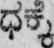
ಧಕ್ಕೆ
